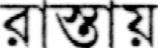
রাস্তায়
